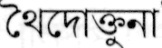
থৈদোক্তুনা
